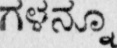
ಗಳನ್ನೂ
